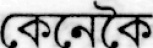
কেনেকৈ
